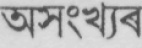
অসংখ্যৰ
